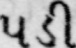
પડી
